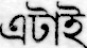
এটাই
